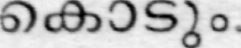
കൊടും.
